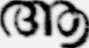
ആ
